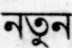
নতুন
